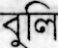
বুলি
